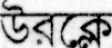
উরক্লে
